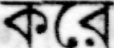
করে
